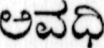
ಅವಧಿ
